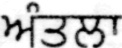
ਅੰਤਲਾ
